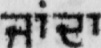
ਜਾਂਦਾ
